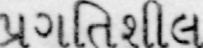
પ્રગતિશીલ
